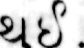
થઈ.
